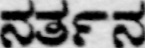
ನರ್ತನ
